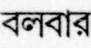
বলবার
